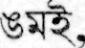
ঙমই,
